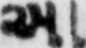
આ
